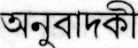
অনুবাদকী
